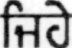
ਜਿਹੇ
